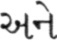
અને
